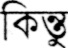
কিন্তু
